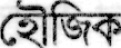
হৌজিক
